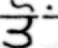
ਤੋਂ
